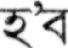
হ'ব
